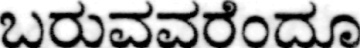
ಬರುವವರೆಂದೂ
